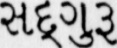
સદગુરૂ
